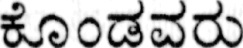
ಕೊಂಡವರು
